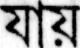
যায়
